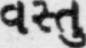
વસ્તુ
